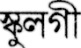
স্কুলগী
